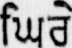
ਘਿਰੇ
